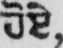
ਹੋਏ,
